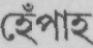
হেঁপাহ
